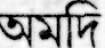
অমদি
